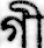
গী
